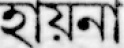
হায়না
